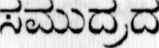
ಸಮುದ್ರದ
